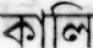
কালি
